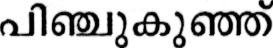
പിഞ്ചുകുഞ്ഞ്
